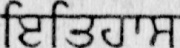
ਇਤਿਹਾਸ
